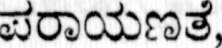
ಪರಾಯಣತೆ,
